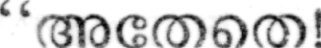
"അതേതെ!
